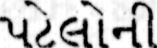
પટેલોની
